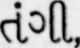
તંગી,
